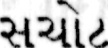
સચોટ
